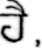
ਹੈ,
